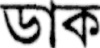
ডাক
